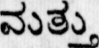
ಮತ್ತು
